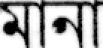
মানা
